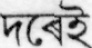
দৰেই
